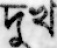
দুখ
